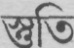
স্তুতি
